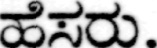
ಹೆಸರು.
